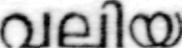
വലിയ
